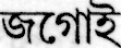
জগোই
